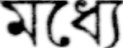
মধ্যে
